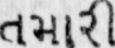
તમારી
